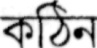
কঠিন
